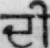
ਦੀ
